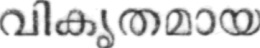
വികൃതമായ
